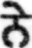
ਨੇ
